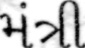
મંત્રી
